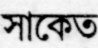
সাকেত
